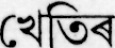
খেতিৰ
